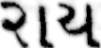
રાય
